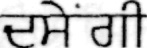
ਦਸੇਂਗੀ
